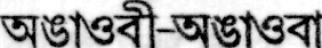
অঙাওবী-অঙাওবা
